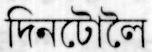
দিনটোলৈ
